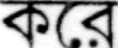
করে
